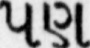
પણ
